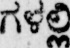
ಗಳಲ್ಲಿ
